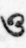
ও
